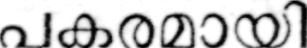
പകരമായി
